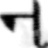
ન
